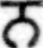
ਨ
